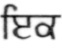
ਇਕ
